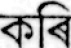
কৰি
